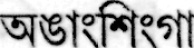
অঙাংশিংগা
